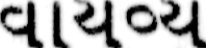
વાયવ્ય
